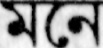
মনে
